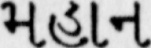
મહાન
